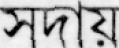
সদায়
